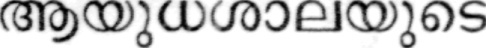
ആയുധശാലയുടെ
